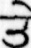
ਤੇ
